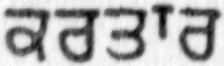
ਕਰਤਾਰ
